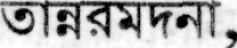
তান্নরমদনা,
